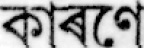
কাৰণে
